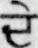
ਦੇ
